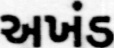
અખંડ
